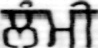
ਲੰਮੀ
